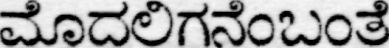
ಮೊದಲಿಗನೆಂಬಂತೆ
